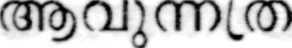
ആവുന്നത്ര
